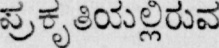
ಪ್ರಕೃತಿಯಲ್ಲಿರುವ
